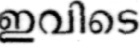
ഇവിടെ
